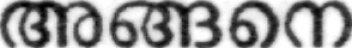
അങ്ങനെ
